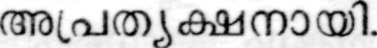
അപ്രത്യക്ഷനായി.
